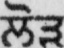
ਲੋੜ
